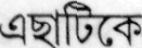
এছাটিকে
